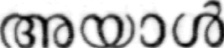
അയാള്‍
